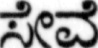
ಸೇವೆ
